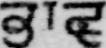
ਭਾਵ
